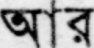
আর
